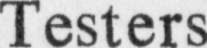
Testers
